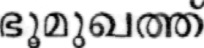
ഭൂമുഖത്ത്
